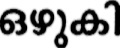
ഒഴുകി
